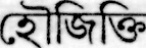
হৌজিক্তি
